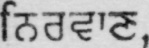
ਨਿਰਵਾਣ,
